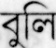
বুলি
